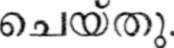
ചെയ്തു.
